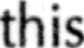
this
